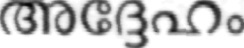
അദ്ദേഹം
